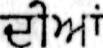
ਦੀਆਂ
